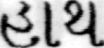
હાથ
